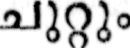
ചുറ്റും
